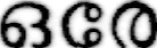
ഒരേ
